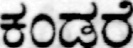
ಕಂಡರೆ
